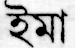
ইমা
